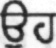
ਉਹ
